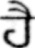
ਹੈ
